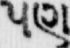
પણ
